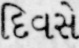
દિવસે
